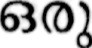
ഒരു
